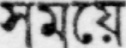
সময়ে
